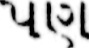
પણ
